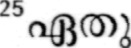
25ഏതു
